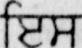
ਇਸ
